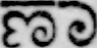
ಣಾ
